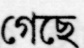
গেছে
